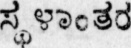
ಸ್ಥಳಾಂತರ
